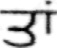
ਤਾਂ
